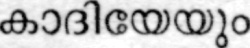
കാദിയേയും
